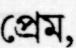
প্রেম,
